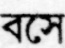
বসে
